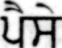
ਪੈਸੇ
